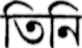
তিনি
